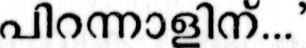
പിറന്നാളിന്...’
